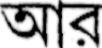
আর
